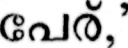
പേര്,’
